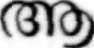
ആ
